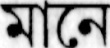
মানে
